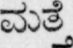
ಮತ್ತೆ
